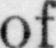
of
